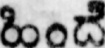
ಹಿಂದೆ
